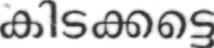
കിടക്കട്ടെ
